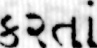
કરતાં
